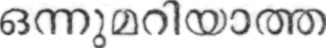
ഒന്നുമറിയാത്ത
